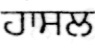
ਹਾਸਲ
